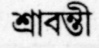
শ্রাবন্তী
